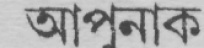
আপুনাক
